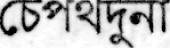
চেপথদুনা
